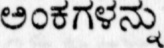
ಅಂಕಗಳನ್ನು
